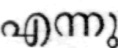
എന്നു
